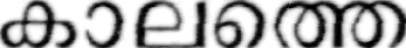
കാലത്തെ
